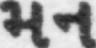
મન
